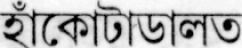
হাঁকোটাডালত
